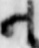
ન
